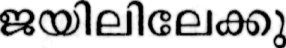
ജയിലിലേക്കു
